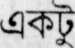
একটু
